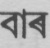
বাৰ
